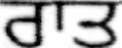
ਰਾਤ
